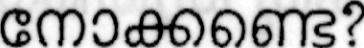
നോക്കണ്ടെ?
